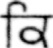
ਕਿ
